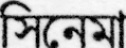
সিনেমা
